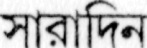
সারাদিন
